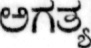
ಅಗತ್ಯ
